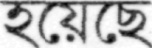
হয়েছে
